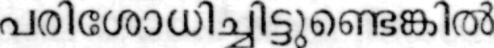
പരിശോധിച്ചിട്ടുണ്ടെങ്കില്‍
